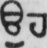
ਉਹ
